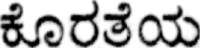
ಕೊರತೆಯ
